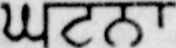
ਘਟਨਾ
